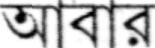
আবার
